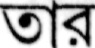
তার
